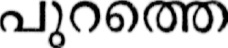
പുറത്തെ
